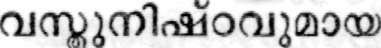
വസ്തുനിഷ്ഠവുമായ
